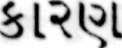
કારણ
